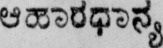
ಆಹಾರಧಾನ್ಯ
